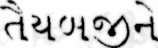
તૈયબજીને
